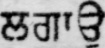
ਲਗਾਉ
